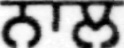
ਨਾਲ
